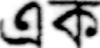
এক
